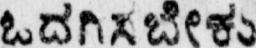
ಒದಗಿಸಬೇಕು
